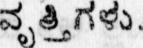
ವೃತ್ತಿಗಳು.
